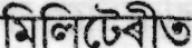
মিলিটেৰীত
